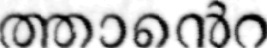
ത്താന്റെ
